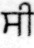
ਸੀ
